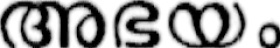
അഭയം
